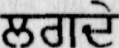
ਲਗਦੇ
